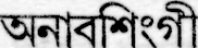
অনাবশিংগী
